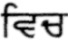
ਵਿਚ
